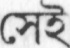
সেই
